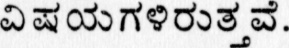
ವಿಷಯಗಳಿರುತ್ತವೆ.
